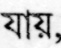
যায়,
